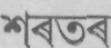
শৰতৰ
